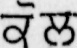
ਕੋਲ
